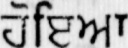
ਹੋਇਆ
